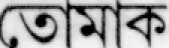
তোমাক
